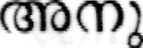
അനു
